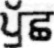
ਪੁੱਛ
